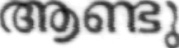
ആണ്ടു
